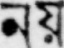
নয়
